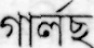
গার্লছ
